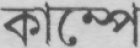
কাম্পে
